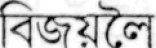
বিজয়লৈ
